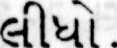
લીધો.
